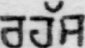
ਰਹੱਸ
